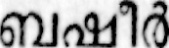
ബഷീര്‍
